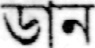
ডান
